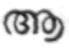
ആ
